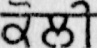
ਕੋਲੀ
